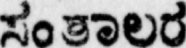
ಸಂತಾಲರ
